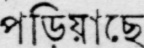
পড়িয়াছে
